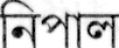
নিপাল
